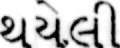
થયેલી
